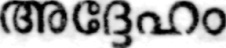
അദ്ദേഹം
